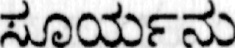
ಸೂರ್ಯನು
